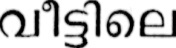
വീട്ടിലെ
